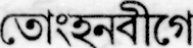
তোংহনবীগে
